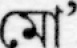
মো'
